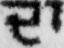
ਦਾ
